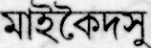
মাইকৈদসু
